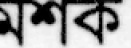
মশক
